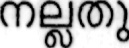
നല്ലതു
